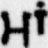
ਮਾਂ
